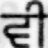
ਵੀ
